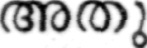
അതു
